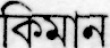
কিমান
